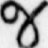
જ
